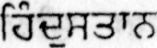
ਹਿੰਦੁਸਤਾਨ
